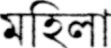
মহিলা
